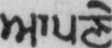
ਆਪਣੇ
